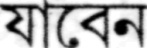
যাবেন
